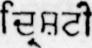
ਦ੍ਰਿਸ਼ਟੀ
